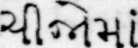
ચીજોમાં
